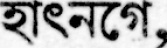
হাৎনগে,
